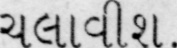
ચલાવીશ.
